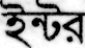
ইন্টর
